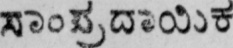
ಸಾಂಪ್ರದಾಯಿಕ
